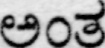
ಅಂತ
